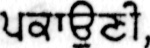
ਪਕਾਉਣੀ,
